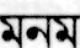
মনম
